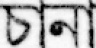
চানা
